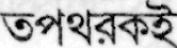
তপথরকই
